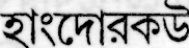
হাংদোরকউ
